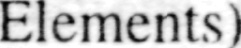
Elements)
